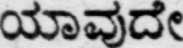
ಯಾವುದೇ
